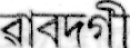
ৱাবদগী
